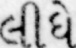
લીધે
